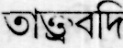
তাক্ত্রবদি
